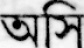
অসি
